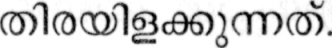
തിരയിളക്കുന്നത്.
